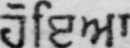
ਹੋਇਆ
